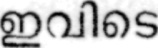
ഇവിടെ
